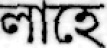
লাহে
